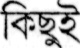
কিছুই
